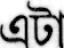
এটা
